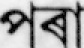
পৰা
